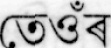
তেওঁৰ
